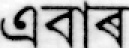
এবাৰ
